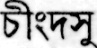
চীংদসু
